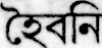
হৈবনি
